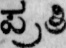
ಪ್ರತಿ
